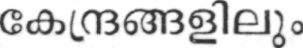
കേന്ദ്രങ്ങളിലും
